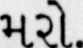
મરો.
